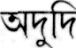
অদুদি
